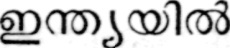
ഇന്ത്യയില്‍
